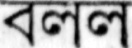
বলল
